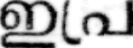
ഇപ്ര
